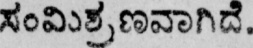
ಸಂಮಿಶ್ರಣವಾಗಿದೆ.
